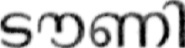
ടൌണി
